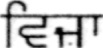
ਵਿਜ਼ਾ
